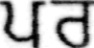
ਪਰ
